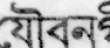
মরমদি
